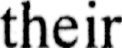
their
